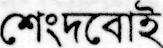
শেংদবোই
